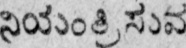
ನಿಯಂತ್ರಿಸುವ
